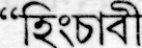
“হিংচাবী
